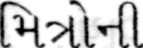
મિત્રોની
